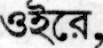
ওইরে,
